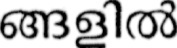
ങ്ങളില്‍
